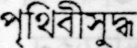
পৃথিবীসুদ্ধ
